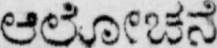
ಆಲೋಚನೆ
